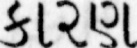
કારણ
